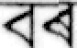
বৰ
